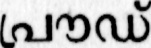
പ്രൌഡ്
